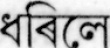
ধৰিলে
